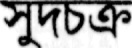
সুদচক্র
